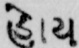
હોય
